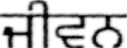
ਜੀਵਨ
